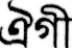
ঐগী
